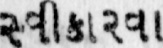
સ્વીકારવા
